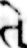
તે
